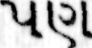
પણ
